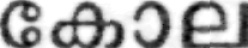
കോല
